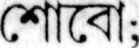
শোবো;
